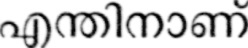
എന്തിനാണ്
